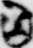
છે
